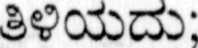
ತಿಳಿಯದು;
